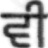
ਵੀ
